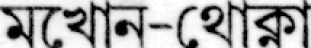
মখোন-থোক্না
